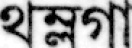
থম্লগা
